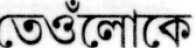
তেওঁলোকে
